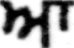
ਆ
